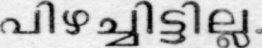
പിഴച്ചിട്ടില്ല.
